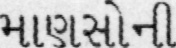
માણસોની
